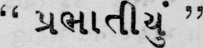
“પ્રભાતીયું”
